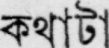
কথাটা
